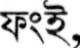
ফংই,
